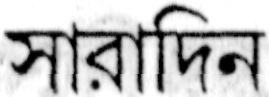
সারাদিন
